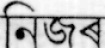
নিজৰ
